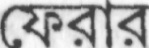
ফেরার
